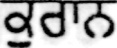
ਕੁਰਾਨ
